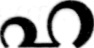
ഹ
